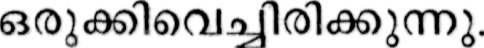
ഒരുക്കിവെച്ചിരിക്കുന്നു.
